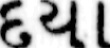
દયા
